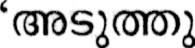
'അടുത്തു
